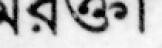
মরক্তা
